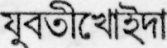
যুবতীখোইদা
